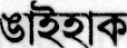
ঙাইহাক
